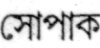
সোপাক
